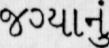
જગ્યાનું
